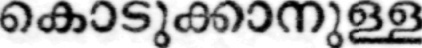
കൊടുക്കാനുള്ള
